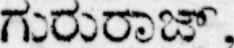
ಗುರುರಾಜ್,
